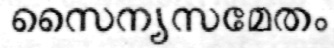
സൈന്യസമേതം
